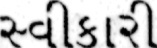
સ્વીકારી
